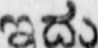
ಇದು
